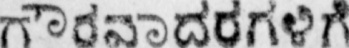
ಗೌರವಾದರಗಳಿಗೆ
